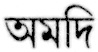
অমদি
